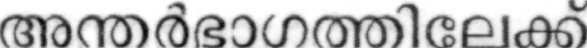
അന്തര്‍ഭാഗത്തിലേക്ക്
